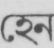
হেন
